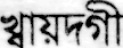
খ্বাইদগী
